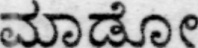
ಮಾಡೋ
